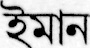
ইমান
